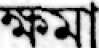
ক্ষমা
